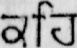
ਕਹਿ
